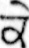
ਕੇ
